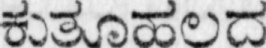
ಕುತೂಹಲದ
